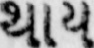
થાય
